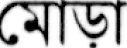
মোড়া
